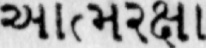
આત્મરક્ષા
